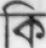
কি
